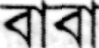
বাবা
